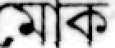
মোক
